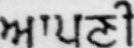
ਆਪਣੀ
